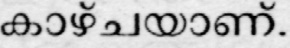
കാഴ്ചയാണ്.
